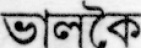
ভালকৈ
